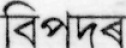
বিপদৰ
